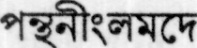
পন্থনীংলমদে
